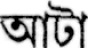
আটা
